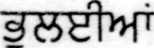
ਭੁਲਈਆਂ
